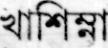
খাশিম্না
